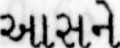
આસને
